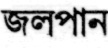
জলপান
